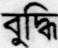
বুদ্ধি
